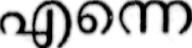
എന്നെ
